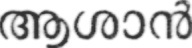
ആശാന്‍
